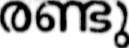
രണ്ടു
